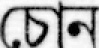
চোন
